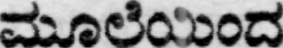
ಮೂಲೆಯಿಂದ
